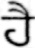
ਹੈ
